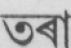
তৰা
